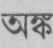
অঙ্ক
